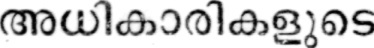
അധികാരികളുടെ
